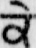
ਕੇ
